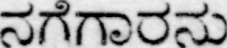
ನಗೆಗಾರನು
